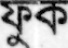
ফুক
